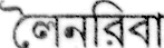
লৈনরিবা
